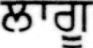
ਲਾਗੂ
